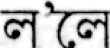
ল'লে
